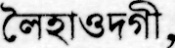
লৈহাওদগী,
